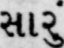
સારું
